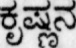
ಕೃಷ್ಣನ
